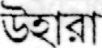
উহারা
